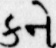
કને
